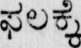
ಫಲಕ್ಕೆ
